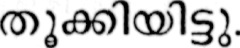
തൂക്കിയിട്ടു.
